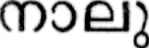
നാലു
